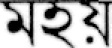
মহয
